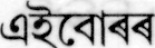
এইবোৰৰ
